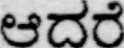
ಆದರೆ
